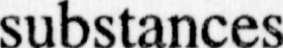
substances
